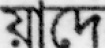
য়াদে
